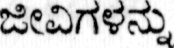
ಜೀವಿಗಳನ್ನು
